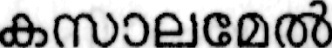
കസാലമേല്‍
